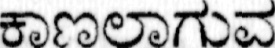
ಕಾಣಲಾಗುವ
